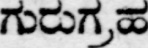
ಗುರುಗ್ರಹ
